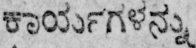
ಕಾರ್ಯಗಳನ್ನು
